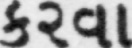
કરવા
